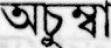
অচুম্বা
